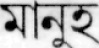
মানুহ
